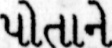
પોતાને
